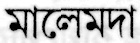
মালেমদা
